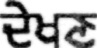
ਦੇਖਣ
